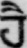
ਹੈ
